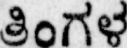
ತಿಂಗಳ
